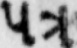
પત્ર
